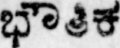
ಭೌತಿಕ
